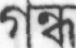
গন্ধ
